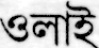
ওলাই
